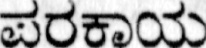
ಪರಕಾಯ
